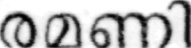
രമണി
